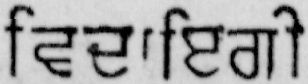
ਵਿਦਾਇਗੀ
